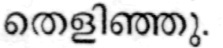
തെളിഞ്ഞു.
